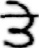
ਤੇ
